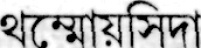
থম্মোয়সিদা
